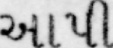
આપી
